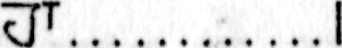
ਹਾ.......................।
